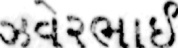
ઝવેરભાઈ
